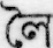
লৈ
